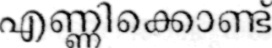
എണ്ണിക്കൊണ്ട്
